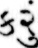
કરું
